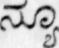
ನ್ಯೂ
